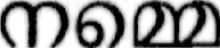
നമ്മെ
